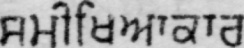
ਸਮੀਖਿਆਕਾਰ
